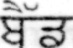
ਬੈੱਡ
